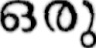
ഒരു
